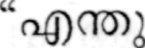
"എന്തു
